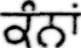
ਕੰਨਾਂ
